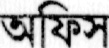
অফিস
